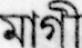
মাগী
